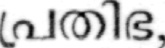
പ്രതിഭ,
